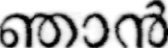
ഞാന്‍
